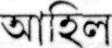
আহিল
